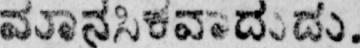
ಮಾನಸಿಕವಾದುದು.
